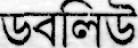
ডবলিউ
